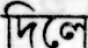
দিলে
